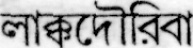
লাক্কদৌরিবা
